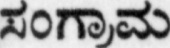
ಸಂಗ್ರಾಮ
